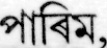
পাৰিম,
